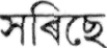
সৰিছে
